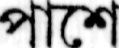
পাশে
